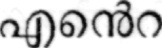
എന്റെ
